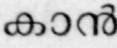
കാന്‍
